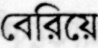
বেরিয়ে
